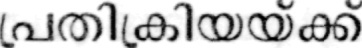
പ്രതിക്രിയയ്ക്ക്
